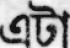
এটা
